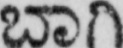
ಬಾಗಿ
